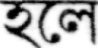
হলে
